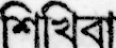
শিখিবা
